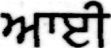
ਆਈ
